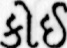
કોઈ
